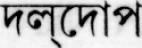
দলদোপ
